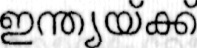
ഇന്ത്യയ്ക്ക്
